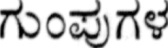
ಗುಂಪುಗಳ
